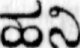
ಹನಿ
